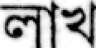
লাখ
